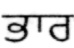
ਭਾਰ
